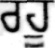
ਰਹੂ
